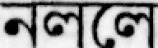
নললে
